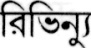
রিভিন্যু
